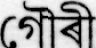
গৌৰী
